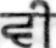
ਵੀ
